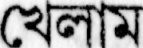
খেলাম
